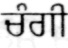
ਚੰਗੀ
